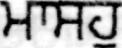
ਮਾਸਹੁ
